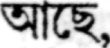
আছে,
